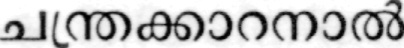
ചന്ത്രക്കാറനാല്‍
